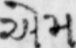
એમ
